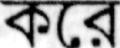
করে
